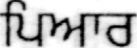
ਪਿਆਰ
